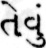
તેવું
